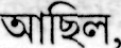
আছিল,
